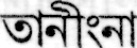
তানীংনা
